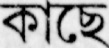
কাছে
